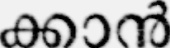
ക്കാന്‍
